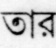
তার
